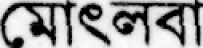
মোৎলবা
